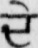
ਦੇ
